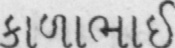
કાળાભાઈ
